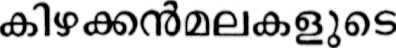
കിഴക്കന്‍മലകളുടെ
